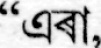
"এৰা,
